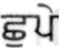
ਛੁਪੇ
